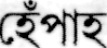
হেঁপাহ
